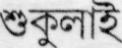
শুকুলাই
